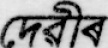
দেৱীৰ
